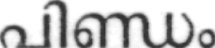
പിണ്ഡം
